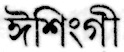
ঈশিংগী
